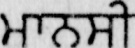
ਮਾਨਸੀ
